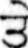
ਤੇ
